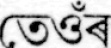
তেওঁৰ
